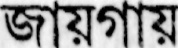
জায়গায়
